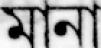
মানা
